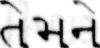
તેમને
